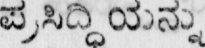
ಪ್ರಸಿದ್ಧಿಯನ್ನು
